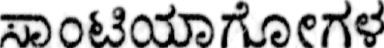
ಸಾಂಟಿಯಾಗೋಗಳ
